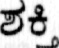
ಶಕ್ತಿ
